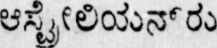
ಆಸ್ಟ್ರೇಲಿಯನ್ರು
